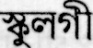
স্কুলগী
